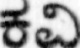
ಕವಿ
